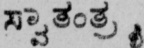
ಸ್ವಾತಂತ್ರ್ಯ
